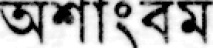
অশাংবম
